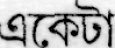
একেটা
